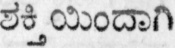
ಶಕ್ತಿಯಿಂದಾಗಿ
